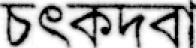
চৎকদবা
